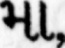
મા,
